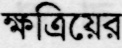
ক্ষত্রিয়ের
